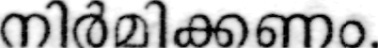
നിര്‍മിക്കണം.
